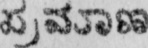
ಪ್ರಮಾಣ
